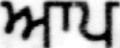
ਆਪ
